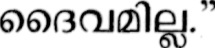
ദൈവമില്ല.”
